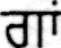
ਗਾਂ
